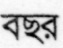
বছর
